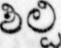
ಶಿಲ್ಪಿ
